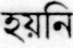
হয়নি
